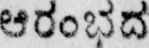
ಆರಂಭದ
